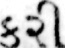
કરી
